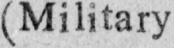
(Military
